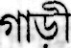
গাড়ী
